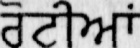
ਰੋਟੀਆਂ
